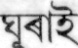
ঘূৰাই
